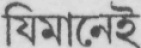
যিমানেই
